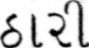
ઠારી
